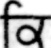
ਕਿ
